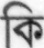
কি
